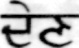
ਦੇਣ
